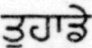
ਤੁਹਾਡੇ
